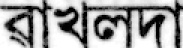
ৱাখলদা
